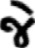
જે
